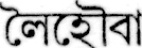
লৈহৌবা
